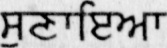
ਸੁਣਾਇਆ
